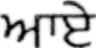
ਆਏ
